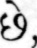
છે.
